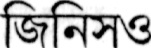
জিনিসও
